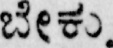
ಬೇಕು.
